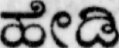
ಹೇಡಿ
